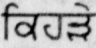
ਕਿਹੜੇ
